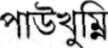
পাউখুম্নি
